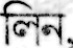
লিন,
